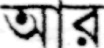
আর
